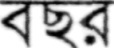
বছর
